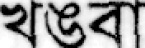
খঙবা
